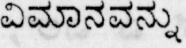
ವಿಮಾನವನ್ನು
